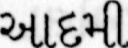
આદમી
